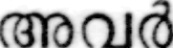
അവര്‍
